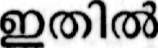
ഇതില്‍
